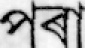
পৰা
